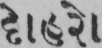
દોહરો
